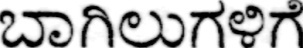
ಬಾಗಿಲುಗಳಿಗೆ
